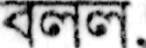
বলল,
